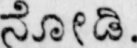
ನೋಡಿ.
